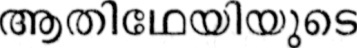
ആതിഥേയിയുടെ
